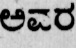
ಅವರ
